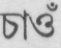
চাওঁ
